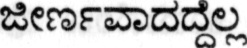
ಜೀರ್ಣವಾದದ್ದೆಲ್ಲ
